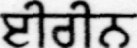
ਈਰੀਨ
